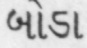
બોડા
